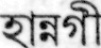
হান্নগী
